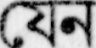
যেন
